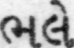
ભલે
